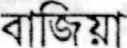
বাজিয়া
